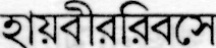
হায়বীররিবসে
